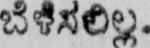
ಬೆಳೆಸಲಿಲ್ಲ.
